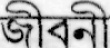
জীবনী
